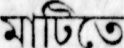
মাটিতে
